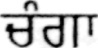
ਚੰਗਾ
